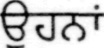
ਉਹਨਾਂ
